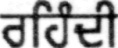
ਰਹਿੰਦੀ
